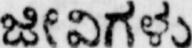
ಜೀವಿಗಳು
